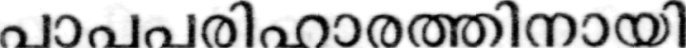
പാപപരിഹാരത്തിനായി
